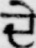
ਦੇ
